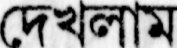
দেখলাম
